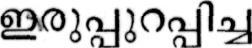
ഇരുപ്പുറപ്പിച്ച
